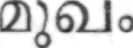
മുഖം
